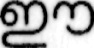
ഈ
